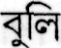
বুলি
